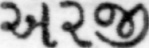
અરજી
